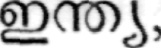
ഇന്ത്യ,
